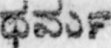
ಧರ್ಮ
